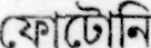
পোটোনি
